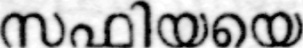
സഫിയയെ
